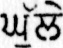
ਘੁੱਲੇ
